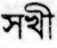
সখী
